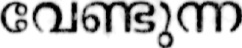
വേണ്ടുന്ന
